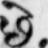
છે.
